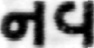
નવ
